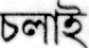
চলাই
